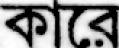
কারে
